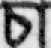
চা
